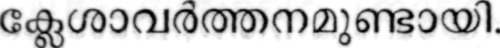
ക്ലേശാവര്‍ത്തനമുണ്ടായി.
